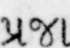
પ્રજા
